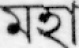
মহা
